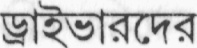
ড্রাইভারদের
